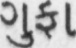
ગુફા
